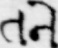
તને
